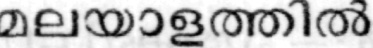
മലയാളത്തില്‍
